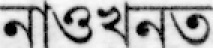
নাওখনত
